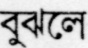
বুঝলে
